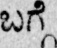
ಬಗ್ಗೆ
